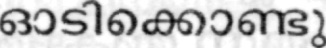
ഓടിക്കൊണ്ടു
